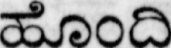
ಹೊಂದಿ
